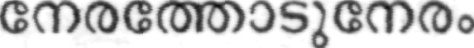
നേരത്തോടുനേരം
